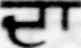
ਦਾ
